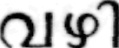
വഴി
